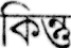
কিন্তু
